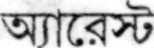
অ্যারেস্ট
